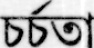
চর্চতা
